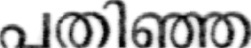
പതിഞ്ഞ
